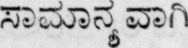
ಸಾಮಾನ್ಯವಾಗಿ
